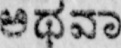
ಅಥವಾ
